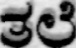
ತಲೆ
